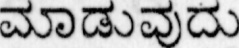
ಮಾಡುವುದು
